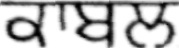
ਕਾਬਲ
